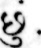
છું.
